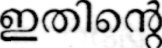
ഇതിന്റെ
